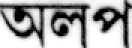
অলপ
